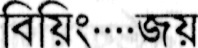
বিয়িং....জয়
